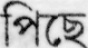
পিছে
